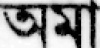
অমা
